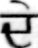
ਦੇ
